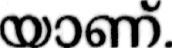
യാണ്.
